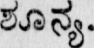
ಶೂನ್ಯ.
